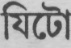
যিটো
